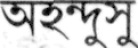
অহন্দুসু
